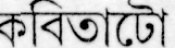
কবিতাটো
